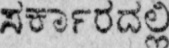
ಸರ್ಕಾರದಲ್ಲಿ
